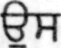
ਉਸ
